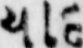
યાદ
